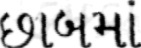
છાબમાં
